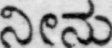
ನೀನು
